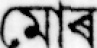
মোৰ
